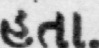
હતા.
